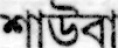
শাউবা
